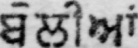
ਬੋਲੀਆਂ
